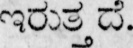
ಇರುತ್ತದೆ.
